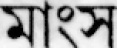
মাংস
